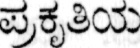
ಪ್ರಕೃತಿಯ
